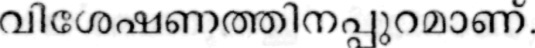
വിശേഷണത്തിനപ്പുറമാണ്.
